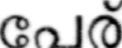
പേര്
